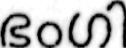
ഭംഗി
